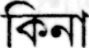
কিনা
